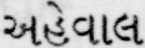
અહેવાલ
